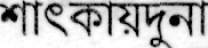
শাৎকায়দুনা
